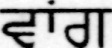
ਵਾਂਗ
